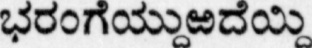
ಭರಂಗೆಯ್ದುಱದೆಯ್ದಿ
